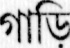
গাড়ি
